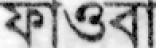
ফাওবা
